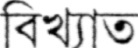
বিখ্যাত
